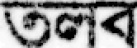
তলব
